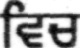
ਵਿਚ
